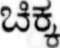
ಚಿಕ್ಕ
